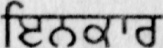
ਇਨਕਾਰ
